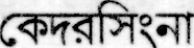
কেদরসিংনা
